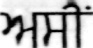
ਅਸੀਂ
